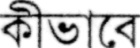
কীভাবে
